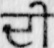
ਦੀ
